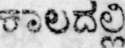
ಕಾಲದಲ್ಲಿ
